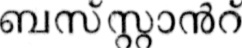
ബസ്സ്റ്റാന്റ്
